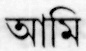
আমি
